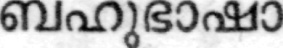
ബഹുഭാഷാ
